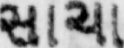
સાચા
